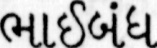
ભાઈબંધ
